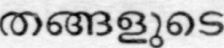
തങ്ങളുടെ
